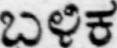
ಬಳಿಕ
